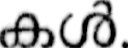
കള്‍.
